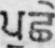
ਪੁਛੇ
